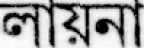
লায়না
